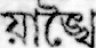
য়াঙ্খৈ
